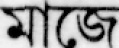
মাজে
